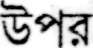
উপর
